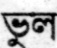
ভুল
